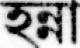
হন্না
